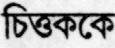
চিত্তককে
